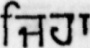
ਜਿਹਾ
